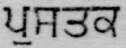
ਪੁਸਤਕ
